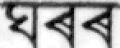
ঘৰৰ
